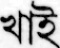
খাই
